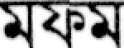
মফম
